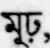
মূঢ়,
